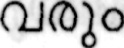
വരും
